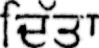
ਦਿੱਤਾ
